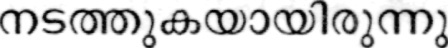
നടത്തുകയായിരുന്നു
